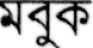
মবুক
